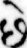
છે
